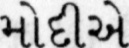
મોદીએ
